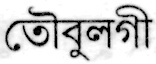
তৌবুলগী
